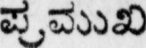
ಪ್ರಮುಖ
